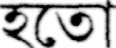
হতো
